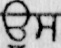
ਉਸ
